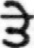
ਤੇ
